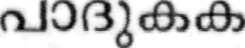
പാദുകക
